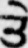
ਤੇ
